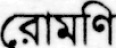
রোমণি
